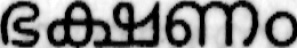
ഭക്ഷണം
